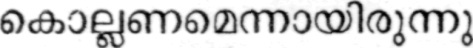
കൊല്ലണമെന്നായിരുന്നു
